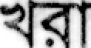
খরা
